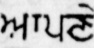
ਆਪਣੇ
